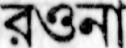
রওনা
